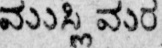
ಮುಸ್ಲಿಮರ
